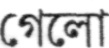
গেলো
